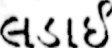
લડાઈ
